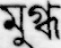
মুগ্ধ
